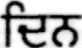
ਦਿਨ
